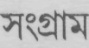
সংগ্ৰাম
